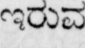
ಇರುವ
